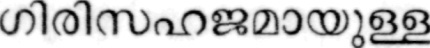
ഗിരിസഹജമായുള്ള
